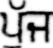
ਪੁੱਜ
